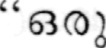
"ഒരു
